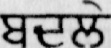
ਬਦਲੇ
